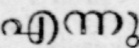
എന്നു
